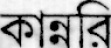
কান্নরি
